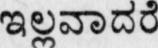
ಇಲ್ಲವಾದರೆ
